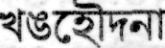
খঙহৌদনা
